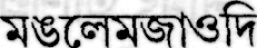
মঙলেমজাওদি
